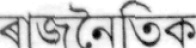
ৰাজনৈতিক
